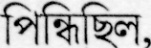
পিন্ধিছিল,
